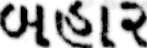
બહાર
